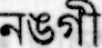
নঙগী
